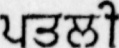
ਪਤਲੀ
